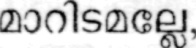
മാറിടമല്ലേ,
